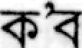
ক'ব
